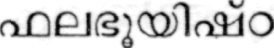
ഫലഭൂയിഷ്ഠ
